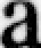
a
